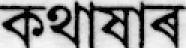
কথাষাৰ
